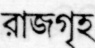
রাজগৃহ
